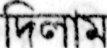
দিলাম
